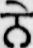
ਨੇ
